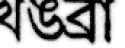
খঙব্রা
